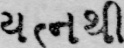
યત્નથી
